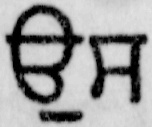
ਉਸ
